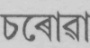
চৰোৱা
